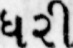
ધરી
